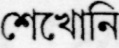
শেখোনি
